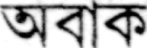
অবাক
